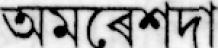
অমৰেশদা
